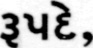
રૂપદે,
